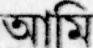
আমি
